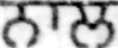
ਨਾਲ
